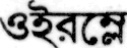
ওইরম্লে
